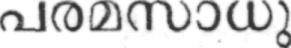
പരമസാധു
